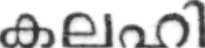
കലഹി
